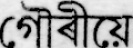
গৌৰীয়ে
